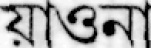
য়াওনা
